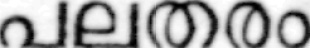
പലതരം
